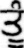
ਤੂੰ
